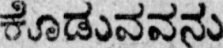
ಕೊಡುವವನು
